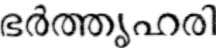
ഭര്‍ത്തൃഹരി
